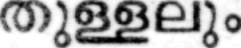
തുള്ളലും
